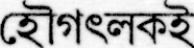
হৌগৎলকই
